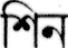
শিন
